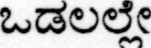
ಒಡಲಲ್ಲೇ
